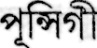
পূন্সিগী
